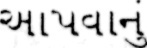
આપવાનું
